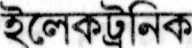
ইলেকট্রনিক
